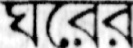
ঘরের
